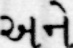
અને
